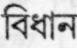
বিধান
